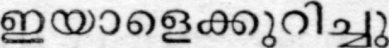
ഇയാളെക്കുറിച്ചു
